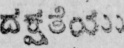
ದಕ್ಷತೆಯು
